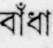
বাঁধা
